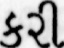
કરી
